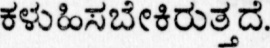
ಕಳುಹಿಸಬೇಕಿರುತ್ತದೆ.
